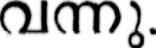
വന്നു.
